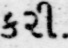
કરી.
